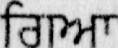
ਗਿਆ
